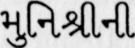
મુનિશ્રીની
